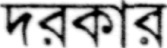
দরকার
